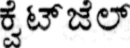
ಕ್ವೆಟ್ಜೆಲ್
